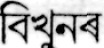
বিখুনৰ
